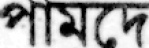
পামদে
